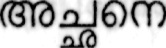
അച്ഛനെ
